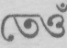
তেওঁ
